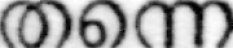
തന്നെ
